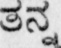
ತನ್ನ
